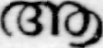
ആ
